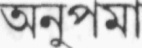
অনুপমা
